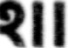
શા
